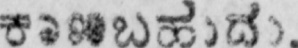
ಕಾಣಬಹುದು.
